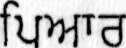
ਪਿਆਰ
